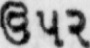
ઉપર
